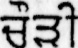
ਚੌੜੀ
